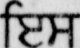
ਇਸ
